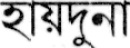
হায়দুনা
